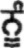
ਨੂੰ
